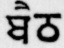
ਬੈਠ
